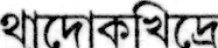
থাদোকখিদ্রে
